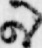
જે
